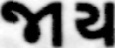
જાય
